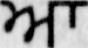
ਆ
